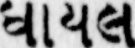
ઘાયલ
